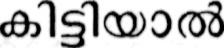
കിട്ടിയാല്‍
